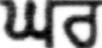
ਘਰ
